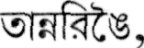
তান্নরিঙৈ,
